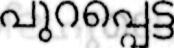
പുറപ്പെട്ട
